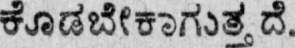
ಕೊಡಬೇಕಾಗುತ್ತದೆ.
